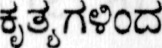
ಕೃತ್ಯಗಳಿಂದ
